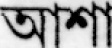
আশা
